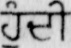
ਹੁੰਦੀ
